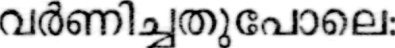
വര്‍ണിച്ചതുപോലെ:
